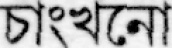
চাংখনো
